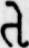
તે
